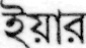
ইয়ার
